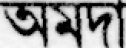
অমদা
